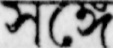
সঙ্গে
